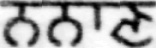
ਨਨਾਣ
